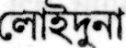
লোইদুনা
